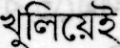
খুলিয়েই
